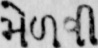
મેળવી
